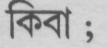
কিবা;
